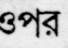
ওপর
